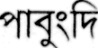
পাবুংদি
